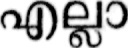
എല്ലാ
